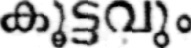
കൂട്ടവും
